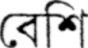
বেশি
